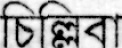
চিল্লিবা
